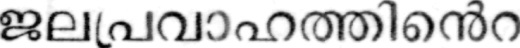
ജലപ്രവാഹത്തിന്റെ
